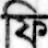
ফি
